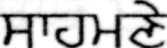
ਸਾਹਮਣੇ
